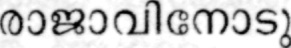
രാജാവിനോടു
